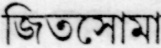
জিতসোমা
